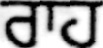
ਰਾਹ
